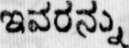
ಇವರನ್ನು
